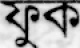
ফুক
